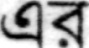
এর
